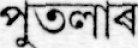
পুতলাৰ
